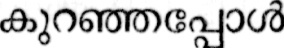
കുറഞ്ഞപ്പോള്‍
